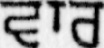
ਵਾਰ
